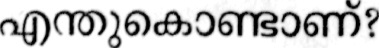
എന്തുകൊണ്ടാണ്?
